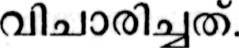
വിചാരിച്ചത്.
